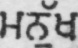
ਮਨੁੱਖ
